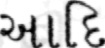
આદિ
